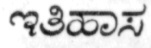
ಇತಿಹಾಸ
